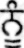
ਨੂੰ
